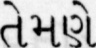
તેમણે
